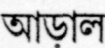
আড়াল
